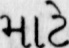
માટે
